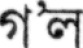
গ'ল
